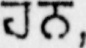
ਹਨ,
